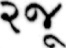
રજૂ
